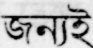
জন্যই
